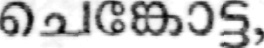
ചെങ്കോട്ട,
